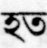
হত
